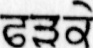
ਫੜਕੇ
